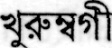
খুরুম্বগী
